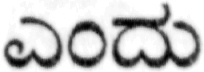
ಎಂದು
